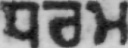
ਧਰਮ
